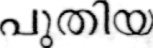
പുതിയ
